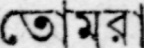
তোমরা
